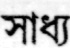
সাধ্য
